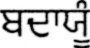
ਬਦਾਯੂ
